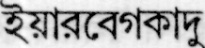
ইয়ারবেগকাদু
